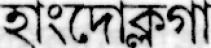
হাংদোক্লগা
